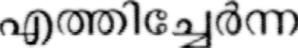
എത്തിച്ചേര്‍ന്ന
